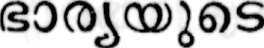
ഭാര്യയുടെ
